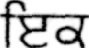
ਇਕ
